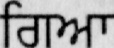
ਗਿਆ
